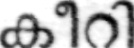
കീറി
